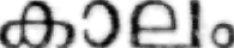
കാലം
